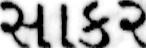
સાકર
